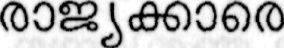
രാജ്യക്കാരെ
